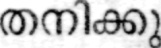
തനിക്കു
